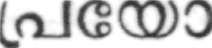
പ്രയോ
